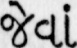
જેવાં
